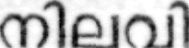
നിലവി
